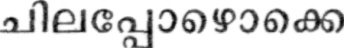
ചിലപ്പോഴൊക്കെ
